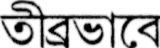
তীব্রভাবে
